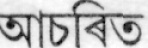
আচৰিত
